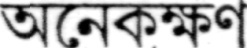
অনেকক্ষণ
